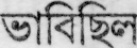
ভাবিছিল
